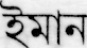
ইমান
